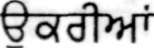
ਉਕਰੀਆਂ
